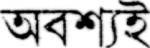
অবশ্যই
